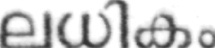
ലധികം
